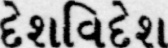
દેશવિદેશ
